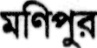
মণিপুর
